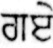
ਗਏ
